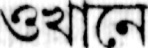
ওখানে
